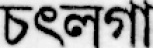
চৎলগা
